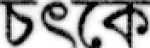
চৎকে
